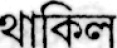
থাকিল
